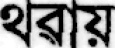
থৱায়
